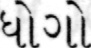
ધોગો
